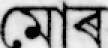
মোৰ
